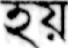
হয়
